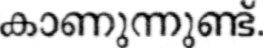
കാണുന്നുണ്ട്.
